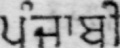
ਪੰਜਾਬੀ
